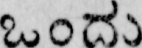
ಒಂದು
